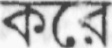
করে
